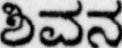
ಶಿವನ
